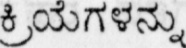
ಕ್ರಿಯೆಗಳನ್ನು
